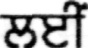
ਲਈਂ
